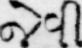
જેવી
